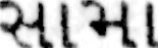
સામા
